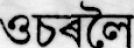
ওচৰলৈ
